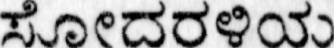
ಸೋದರಳಿಯ
